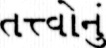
તત્ત્વોનું
